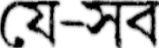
যে-সব
